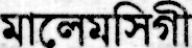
মালেমসিগী
